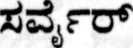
ಸರ್ವೈರ್
